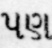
પણ
